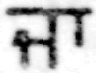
ਜਾ
